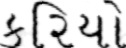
કરિયો
